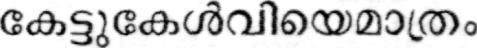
കേട്ടുകേള്‍വിയെമാത്രം
